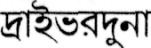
দ্রাইভরদুনা
